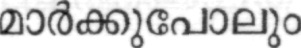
മാര്‍ക്കുപോലും
